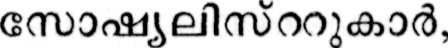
സോഷ്യലിസ്ററുകാര്‍,
